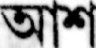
আশ
